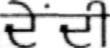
ਦੇਂਦੀ
